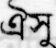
ঐসু
